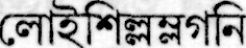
লোইশিল্লম্লগনি
